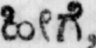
ಹೀಗೆ,
